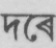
দৰে
